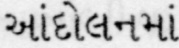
આંદોલનમાં
